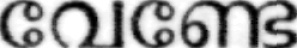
വേണ്ടേ
